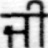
ਜੀ
